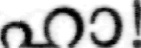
ഹാ!
